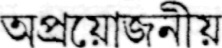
অপ্রয়োজনীয়
